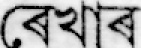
ৰেখাৰ
